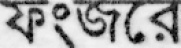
ফংজরে
